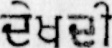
ਦੇਖਦੀ
